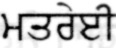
ਮਤਰੇਈ
